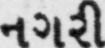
નગરી
